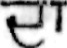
ਦਾ
